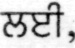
ਲਈ,
